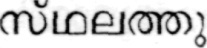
സ്ഥലത്തു
